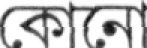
কোনো
